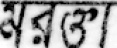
মরক্তা
